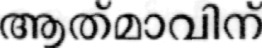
ആത്മാവിന്
